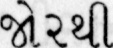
જોરથી
